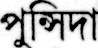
পুন্সিদা
